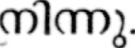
നിന്നു.
